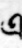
এ
